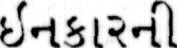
ઈનકારની
